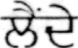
ਲੈਂਦੇ
